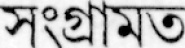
সংগ্রামত
